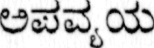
ಅಪವ್ಯಯ
